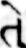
તે
